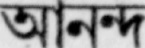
আনন্দ
